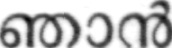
ഞാന്‍
